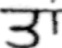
ਤਾਂ
